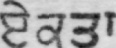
ਏਕਤਾ
